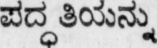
ಪದ್ಧತಿಯನ್ನು
